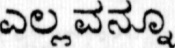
ಎಲ್ಲವನ್ನೂ
